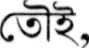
তৌই,
